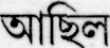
আছিল
